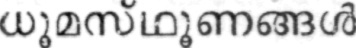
ധൂമസ്ഥൂണങ്ങള്‍
